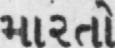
મારતો
